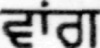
ਵਾਂਗ
